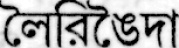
লৈরিঙৈদা
